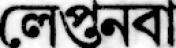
লেপ্তনবা
